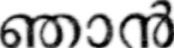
ഞാന്‍
